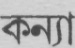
কন্যা
